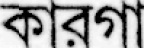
কারগা
